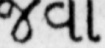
જવા
